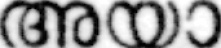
അയാ
